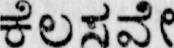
ಕೆಲಸವೇ
